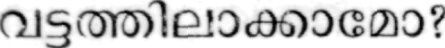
വട്ടത്തിലാക്കാമോ?
